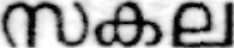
സകല
